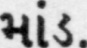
માંડ.
